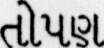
તોપણ
